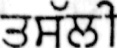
ਤਸੱਲੀ
